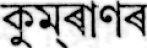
কুম্‌ৰাণৰ
